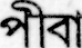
পীবা
